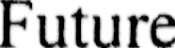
Future
